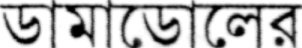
ডামাডোলের
